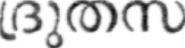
ദ്രുതസ
